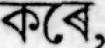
কৰে,
